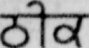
ਠੀਕ
